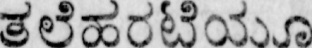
ತಲೆಹರಟೆಯೂ
